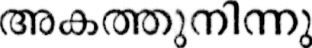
അകത്തുനിന്നു
